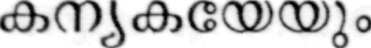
കന്യകയേയും
